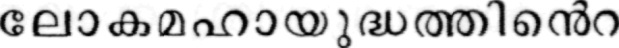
ലോകമഹായുദ്ധത്തിന്റെ
